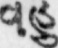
વહુ
